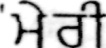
'ਮੇਰੀ
